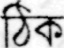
ঠিক
